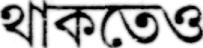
থাকতেও
